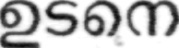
ഉടനെ
